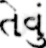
તેવું
